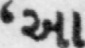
'આ
